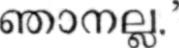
ഞാനല്ല.'
